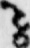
કે
